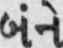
બંને
